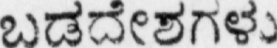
ಬಡದೇಶಗಳು
